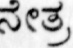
ನೇತ್ರ
